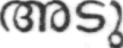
അടു
